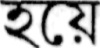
হয়ে
